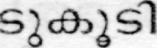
ടുകൂടി
